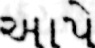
આપે
